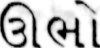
ઊભો
